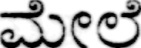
ಮೇಲೆ
